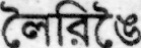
লৈরিঙৈ
